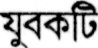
যুবকটি
